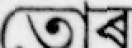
তোৰ
